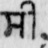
ਸੀ,
